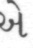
એ
